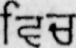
ਵਿਚ
